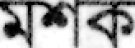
মশক
